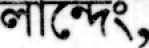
লান্দোং,
